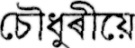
চৌধুৰীয়ে
